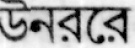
উনররে
